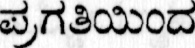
ಪ್ರಗತಿಯಿಂದ
